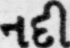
નદી
